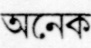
অনেক
